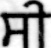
ਸੀ
